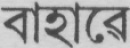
বাহাৱে
